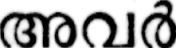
അവര്‍
